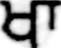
ਖਾ
